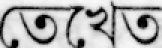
তেখেত
